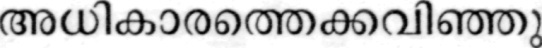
അധികാരത്തെക്കവിഞ്ഞു
